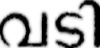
വടി
